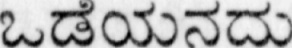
ಒಡೆಯನದು
